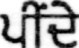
ਪੀਂਦੇ
